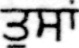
ਤੁਸਾਂ
